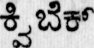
ಕ್ವಿಬೆಕ್
